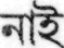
নাই
